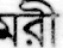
মরী
